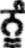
ਨੂੰ
